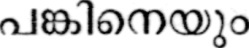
പങ്കിനെയും
